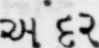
અંદર
